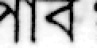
পাব
